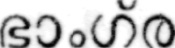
ഭാംഗ്‌ര
